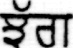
ਝੱਗ
